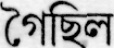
গৈছিল
